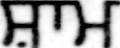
ਸ਼ਾਮ
